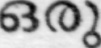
ഒരു
